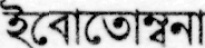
ইবোতোম্বনা
